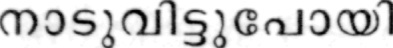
നാടുവിട്ടുപോയി
